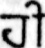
ਹੀ
